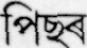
পিছৰ
